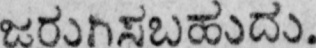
ಜರುಗಿಸಬಹುದು.
